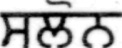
ਸਲੋਨ
